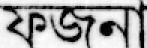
ফজনা
